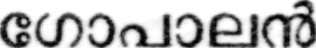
ഗോപാലന്‍
